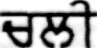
ਚਲੀ
